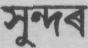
সুন্দৰ
